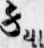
કયા
